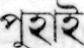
পুহাই
